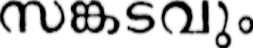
സങ്കടവും
